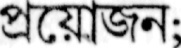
প্রয়োজন;
